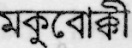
মকুবোক্কী
